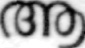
ആ
